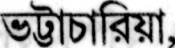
ভট্টাচারিয়া,
